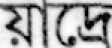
য়াদ্রে
